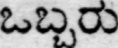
ಒಬ್ಬರು
